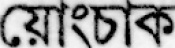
য়োংচাক
